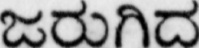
ಜರುಗಿದ
